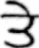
ਤੇ
